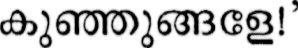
കുഞ്ഞുങ്ങളേ!'
